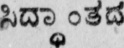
ಸಿದ್ದಾಂತದ
